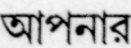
আপনার
